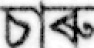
চাৰু
